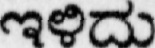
ಇಳಿದು
